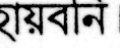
হায়বনি
